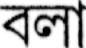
বলা
